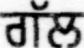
ਗੱਲ
